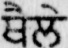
ਥੈਲੇ
